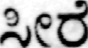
ಸೀರೆ
